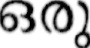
ഒരു
